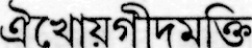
ঐখোয়গীদমক্তি
